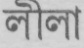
লীলা
